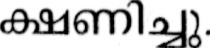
ക്ഷണിച്ചു.
